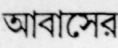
আবাসের
